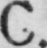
C.
